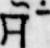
ਸੋਂ
